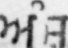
ਅੰਸ਼
